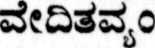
ವೇದಿತವ್ಯಂ
